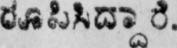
ರೂಪಿಸಿದ್ದಾರೆ.
